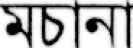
মচানা
